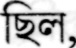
ছিল,
